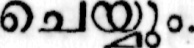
ചെയ്യും.
